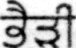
ਭੈੜੀ
